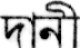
দানী
